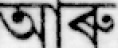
আৰু
